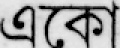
একো
